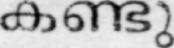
കണ്ടു
